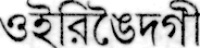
ওইরিঙৈদগী
